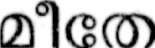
മീതേ
